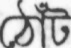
ঠোঁট
